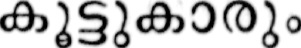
കൂട്ടുകാരും
